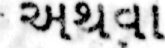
અથવા
